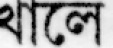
খালে
